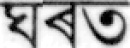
ঘৰত
